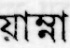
য়াম্না
